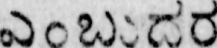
ಎಂಬುದರ
